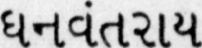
ધનવંતરાય
